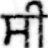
ਸੀ
